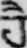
ਹੈ
